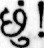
છું!
